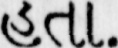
હતા.
